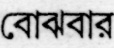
বোঝবার
